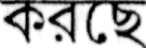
করছে
